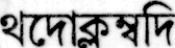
থদোক্লম্বদি
